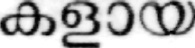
കളായ
